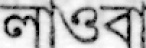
লাওবা
